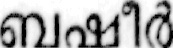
ബഷീര്‍
